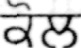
ਕੋਲ
